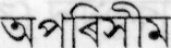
অপৰিসীম
